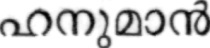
ഹനുമാന്‍
